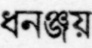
ধনঞ্জয়
